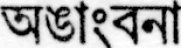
অঙাংবনা
